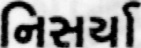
નિસર્યા
